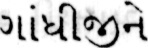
ગાંધીજીને
